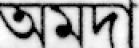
অমদা
